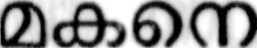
മകനെ
